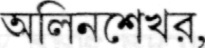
অলিনশেখর,
